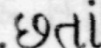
છતાં
